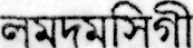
লমদমসিগী
